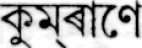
কুম্‌ৰাণে
